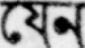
যেন
